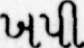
ખપી
